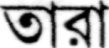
তারা
